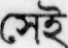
সেই
